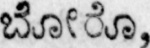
ಬೋರೊ,
